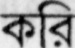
করি
